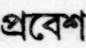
প্রবেশ
